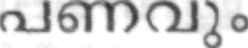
പണവും
